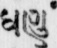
ઘણું
